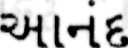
આનંદ
